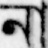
না
